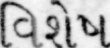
વિશેષ
